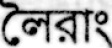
লৈরাং
